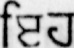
ਇਹ
